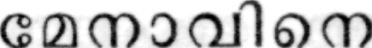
മേനാവിനെ
